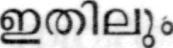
ഇതിലും
